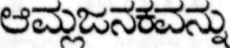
ಆಮ್ಲಜನಕವನ್ನು
